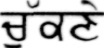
ਚੁੱਕਣੇ
